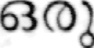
ഒരു
